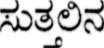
ಸುತ್ತಲಿನ
